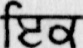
ਇਕ
